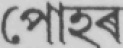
পোহৰ
